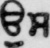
ਉਸ
